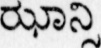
ಝಾನ್ಸಿ
